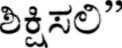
ಶಿಕ್ಷಿಸಲಿ"
